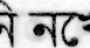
নখে
